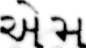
એમ
